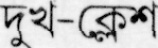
দুখ-ক্লেশ
